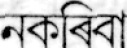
নকৰিবা
